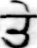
ਤੇ
